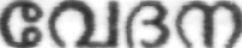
വേദന
